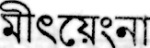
মীৎয়েংনা
